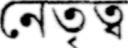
নেতৃত্ব
